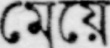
মেয়ে
